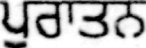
ਪੁਰਾਤਨ
